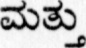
ಮತ್ತು
